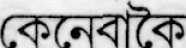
কেনেবাকৈ
